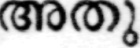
അതു
